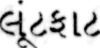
લૂંટફાટ
